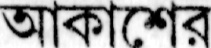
আকাশের
